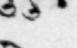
પુરુષ
